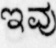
ಇವು
